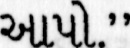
આપો."
